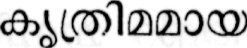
കൃത്രിമമായ
